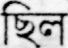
ছিল
